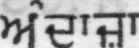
ਅੰਦਾਜ਼ਾ
